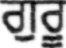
ਗੁਰੂ
